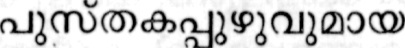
പുസ്തകപ്പുഴുവുമായ
